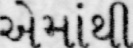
એમાંથી
